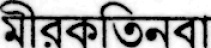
মীরকতিনবা
